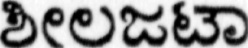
ಶೀಲಜಟಾ
